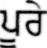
ਪੂਰੇ
